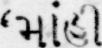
'માંહી
